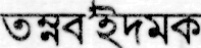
তম্নব’ইদমক
